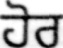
ਹੋਰ
